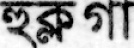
হুক্লগা
